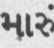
મારું
